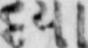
દયા
